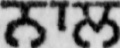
ਨਾਲ
